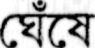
ঘেঁষে
